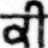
ਕੀ
